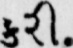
કરી
